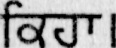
ਕਿਹਾ।
